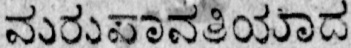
ಮರುಪಾವತಿಯಾದ
